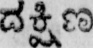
ದಕ್ಷಿಣ
